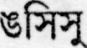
ঙসিসু
